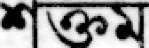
শক্তম
